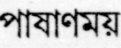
পাষাণময়
